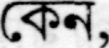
কেন,
